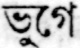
ভুগে
